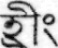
হ্রীং
